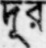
দূর
